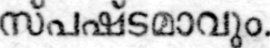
സ്പഷ്ടമാവും.
